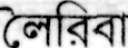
লৈরিবা
